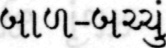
બાળ-બચ્ચું
